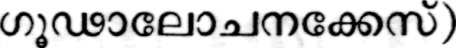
ഗൂഢാലോചനക്കേസ്)
